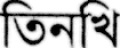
তিনখি
